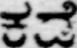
ಕಡೆ
